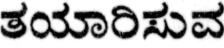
ತಯಾರಿಸುವ
